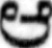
ಆ
